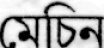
মেচিন
